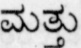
ಮತ್ತು
